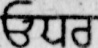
ਓਧਰ
